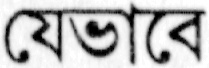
যেভাবে
